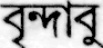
বৃন্দাবু
